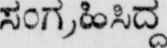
ಸಂಗ್ರಹಿಸಿದ್ದ
